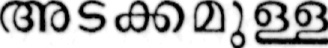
അടക്കമുള്ള
